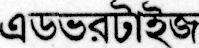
এডভরটাইজ
